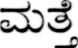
ಮತ್ತೆ
